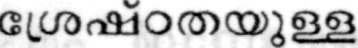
ശ്രേഷ്ഠതയുള്ള
